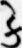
કે
